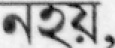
নহয়,
